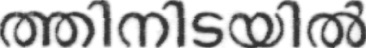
ത്തിനിടയില്‍
